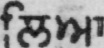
ਲਿਆ
